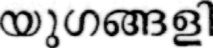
യുഗങ്ങളി
